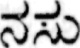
ನಸು
